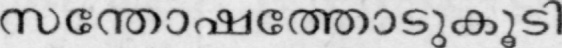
സന്തോഷത്തോടുകൂടി
